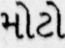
મોટો
